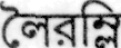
লৈরম্লি
